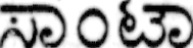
ಸಾಂಟಾ
